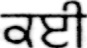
ਕਈ
